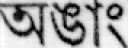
অঙাং
